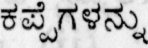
ಕಪ್ಪೆಗಳನ್ನು
